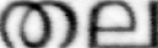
തല
